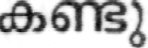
കണ്ടു
